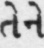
તેને
